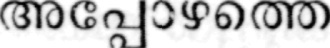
അപ്പോഴത്തെ
